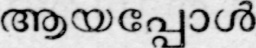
ആയപ്പോള്‍
